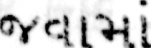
જવામાં
